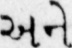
અને
